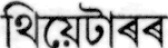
থিয়েটাৰৰ
